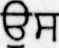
ਉਸ
